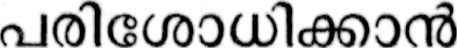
പരിശോധിക്കാന്‍
